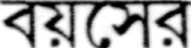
বয়সের
